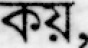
কয়,
